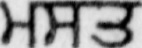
ਮਸਤ
